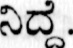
ನಿದ್ದೆ.
